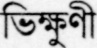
ভিক্ষুণী
